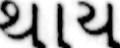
થાય
